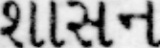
શાસન
